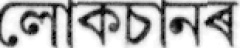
লোকচানৰ
